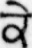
ਕੇ
